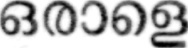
ഒരാളെ
